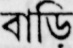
বাড়ি
